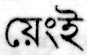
য়েংই
